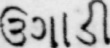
ઉગાડી
